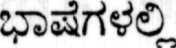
ಭಾಷೆಗಳಲ್ಲಿ
